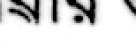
ৱার
